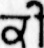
ਕੀ
